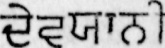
ਦੇਵਯਾਨੀ
